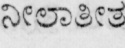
ನೀಲಾತೀತ
